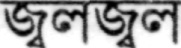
জ্বলজ্বল
